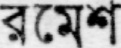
রমেশ
